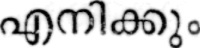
എനിക്കും
